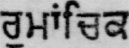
ਰੁਮਾਂਚਿਕ
